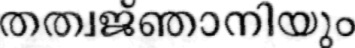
തത്വജ്ഞാനിയും
